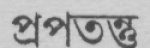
প্ৰপতন্তু
